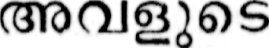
അവളുടെ
